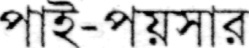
পাই-পয়সার
